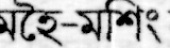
মহৈ-মশিং
